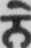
ਨੇ
